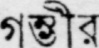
গম্ভীর
